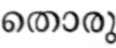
തൊരു
